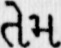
તેમ
